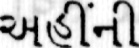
અહીંની
